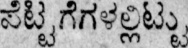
ಪೆಟ್ಟಿಗೆಗಳಲ್ಲಿಟ್ಟು
